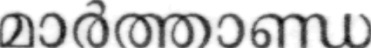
മാര്‍ത്താണ്ഡ
